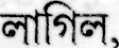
লাগিল,
